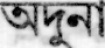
অদুনা
